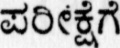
ಪರೀಕ್ಷೆಗೆ
